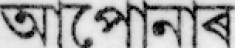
আপোনাৰ
